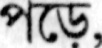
পড়ে,
